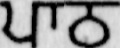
ਪਾਠ
